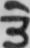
ਤੇ
